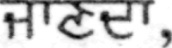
ਜਾਣਦਾ,
